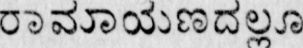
ರಾಮಾಯಣದಲ್ಲೂ
